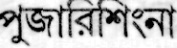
পুজারিশিংনা
